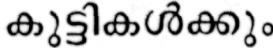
കുട്ടികള്‍ക്കും
